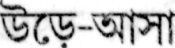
উড়ে-আসা
